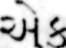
એક
